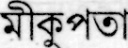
মীকুপতা
